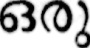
ഒരു
